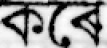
কৰে
